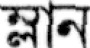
ম্লান
